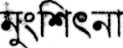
নুংশিৎনা
